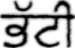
ਭੱਟੀ
